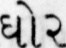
ઘોર
